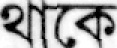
থাকে
